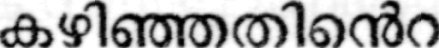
കഴിഞ്ഞതിന്റെ
